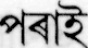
পৰাই
